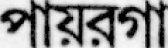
পায়রগা
